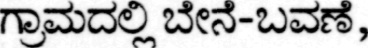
ಗ್ರಾಮದಲ್ಲಿಬೇನೆ-ಬವಣೆ,
